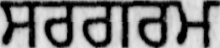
ਸਰਗਰਮ
